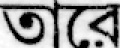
তারে
